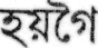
হয়গৈ
